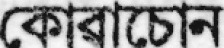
কোৱাচোন
